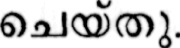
ചെയ്തു.
